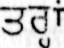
ਤਰ੍ਹਾਂ
